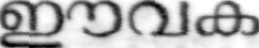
ഈവക
